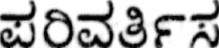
ಪರಿವರ್ತಿಸ
